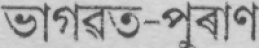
ভাগৱত-পুৰাণ,
